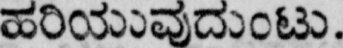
ಹರಿಯುವುದುಂಟು.
